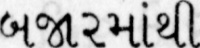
બજારમાંથી
